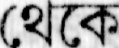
থেকে
